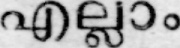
എല്ലാം
